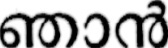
ഞാന്‍
